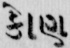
કોણ
